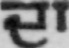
ਦਾ
